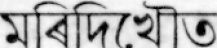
মৰিদিখৌত
